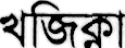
খজিক্না
